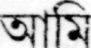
আমি
